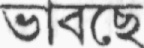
ভাবছে
